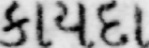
કાયદા
